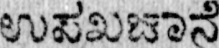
ಉಪಖಜಾನೆ
